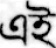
এই
